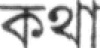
কথা
